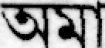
অমা
